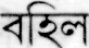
বহিল
